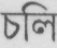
চলি
